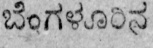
ಬೆಂಗಳೂರಿನ
